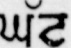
ਘੱਟ
